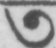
ত
